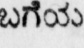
ಬಗೆಯ
